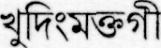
খুদিংমক্তগী
